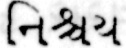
નિશ્ચય
